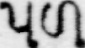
પળ
